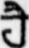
ਹੈ
